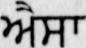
ਐਸਾ
